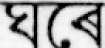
ঘৰে
